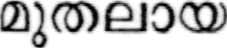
മുതലായ
